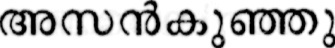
അസന്‍കുഞ്ഞു
